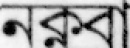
নক্নবা
